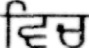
ਵਿਚ
